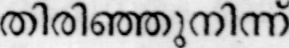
തിരിഞ്ഞുനിന്ന്
